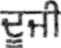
ਦੂਜੀ
